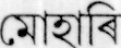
মোহাৰি
